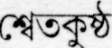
শ্বেতকুষ্ঠ
